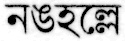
নঙহল্লে
